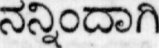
ನನ್ನಿಂದಾಗಿ
